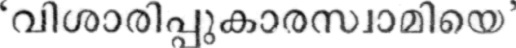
'വിശാരിപ്പുകാരസ്വാമിയെ'
